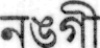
নঙগী
